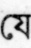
যে
